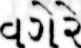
વગેરે
